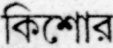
কিশোর
